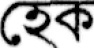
হেক
